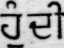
ਹੁੰਦੀ
